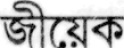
জীয়েক
